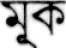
মূক
